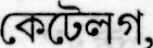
কেটেলগ,
